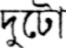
দুটো
